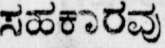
ಸಹಕಾರವು
